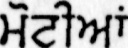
ਮੋਟੀਆਂ
